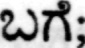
ಬಗೆ;
